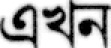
এখন
